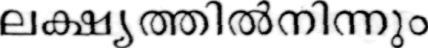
ലക്ഷ്യത്തില്‍നിന്നും
